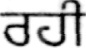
ਰਹੀ
